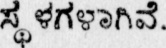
ಸ್ಥಳಗಳಾಗಿವೆ.
